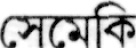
সেমেকি
